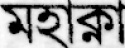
মহাক্না
